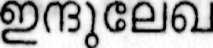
ഇന്ദുലേഖ
